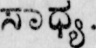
ಸಾಧ್ಯ.
